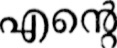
എന്റെ
